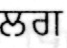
ਲਗ
